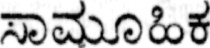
ಸಾಮೂಹಿಕ
